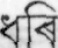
ধৰি
